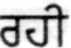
ਰਹੀ
